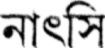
নাৎসি
